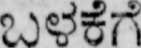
ಬಳಕೆಗೆ
